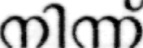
നിന്ന്
